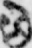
છે
